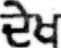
ਦੇਖ
